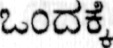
ಒಂದಕ್ಕೆ
